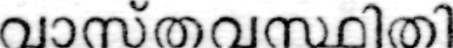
വാസ്തവസ്ഥിതി
